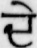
ਦੇ
